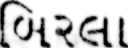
બિરલા
